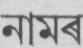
নামৰ
